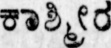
ಕಾಶ್ಮೀರ
